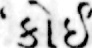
'કોઈ
